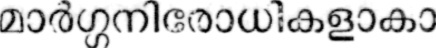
മാര്‍ഗ്ഗനിരോധകളാകാ
